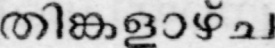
തിങ്കളാഴ്ച
